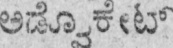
ಅಡ್ವೊಕೇಟ್
